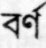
বর্ণ
